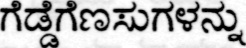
ಗೆಡ್ಡೆಗೆಣಸುಗಳನ್ನು
